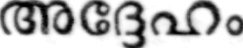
അദ്ദേഹം
